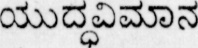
ಯುದ್ಧವಿಮಾನ
